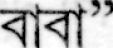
বাবা”
